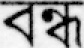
বন্ধ
